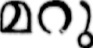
മറു
